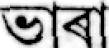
ভাৰা
